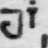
ਹਾਂ,
